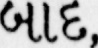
બાદ,
